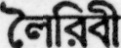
লৈরিবী
